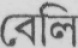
বেলি
